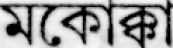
মকোক্কা
